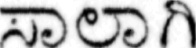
ಸಾಲಾಗಿ
